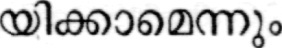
യിക്കാമെന്നും
